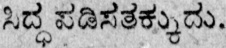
ಸಿದ್ಧಪಡಿಸತಕ್ಕುದು.
